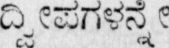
ದ್ವೀಪಗಳನ್ನೇ
